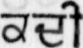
ਕਦੀ
